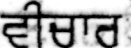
ਵੀਚਾਰ
